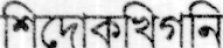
শিদোকখিগনি
